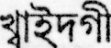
খ্বাইদগী
